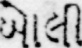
બોલી
